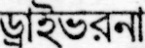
ড্রাইভরনা
